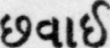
છવાઈ
